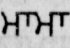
ਮਾਮਾ
